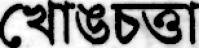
খোঙচত্তা
